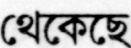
থেকেছে
